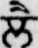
ਲੈ
